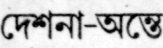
দেশনা-অন্তে
